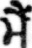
ਮੈਂ
